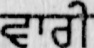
ਵਾਰੀ
